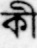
কী
